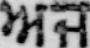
ਅਜ
